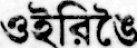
ওইরিঙৈ
